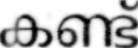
കണ്ട്
